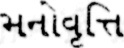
મનોવૃત્તિ
